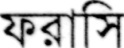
ফরাসি
